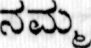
ನಮ್ಮ
